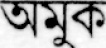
অমুক
